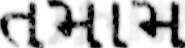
તમામ
